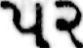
પર
